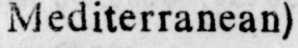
Mediterranean)
